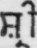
ਸ਼੍ਰੀ
